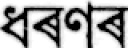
ধৰণৰ
